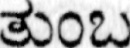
ತುಂಬ
